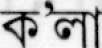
ক'লা
